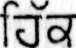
ਹਿੱਕ
